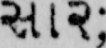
સાર;
